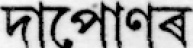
দাপোণৰ
